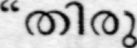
“തിരു
